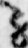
કે
